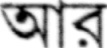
আর
